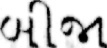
બીજા
